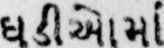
ઘડીઓમાં
